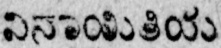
ವಿನಾಯಿತಿಯ
